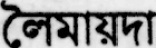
লৈমায়দা
